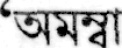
‘অমম্বা
